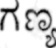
ಗಣ್ಯ
